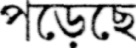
পড়েছে
